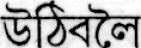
উঠিবলৈ
